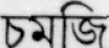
চমজি
